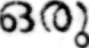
ഒരു
